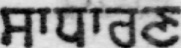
ਸਾਧਾਰਣ
